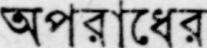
অপরাধের
